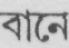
বানে
